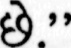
છે."
